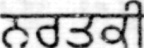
ਨਰਤਕੀ
